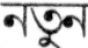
নতুন
